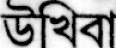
উখিবা
